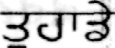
ਤੁਹਾਡੇ
